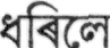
ধৰিলে
